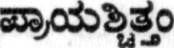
ಪ್ರಾಯಶ್ಚಿತ್ತಂ
